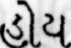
હોય
